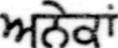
ਅਨੇਕਾਂ
